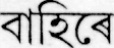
বাহিৰে
